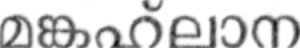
മങ്കഹ്ലാന
